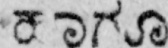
ಹಾಗೂ
